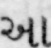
આ
